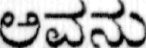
ಅವನು
